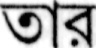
তার
